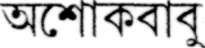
অশোকবাবু
